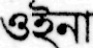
ওইনা
